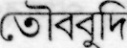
তৌববুদি
